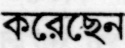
করেছেন
